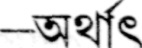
-অর্থাৎ
